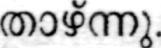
താഴ്ന്നു.
